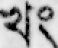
খং
